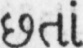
છતાં
